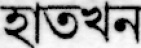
হাতখন
